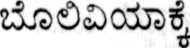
ಬೊಲಿವಿಯಾಕ್ಕೆ
